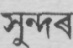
সুন্দৰ
